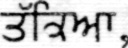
ਤੱਕਿਆ,
